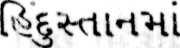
હિંદુસ્તાનમાં
